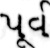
પૂર્વ
